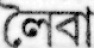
লৈবা
